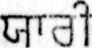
ਯਾਰੀ
